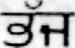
ਭੱਜ
